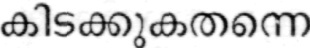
കിടക്കുകതന്നെ
